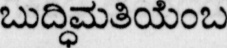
ಬುದ್ಧಿಮತಿಯೆಂಬ
